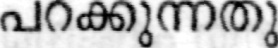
പറക്കുന്നതു
